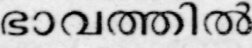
ഭാവത്തില്‍
